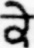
ਕੇ
